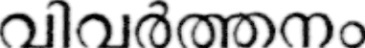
വിവര്‍ത്തനം
